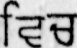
ਵਿਚ
